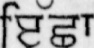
ਇੱਛਾ
